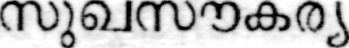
സുഖസൌകര്യ
